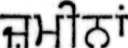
ਜ਼ਮੀਨਾਂ
